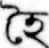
হৈ
